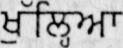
ਖੁੱਲ੍ਹਿਆ
